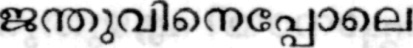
ജന്തുവിനെപ്പോലെ
